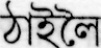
ঠাইলৈ
